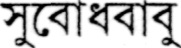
সুবোধবাবু
